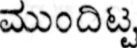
ಮುಂದಿಟ್ಟ,
